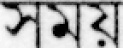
সময়
